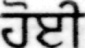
ਹੋਈ
